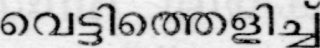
വെട്ടിത്തെളിച്ച്
